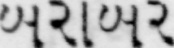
બરાબર
